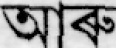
আৰু
